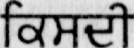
ਕਿਸਦੀ
